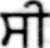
ਸੀ
